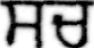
ਸਚ
